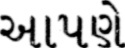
આપણે
